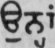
ਉਨ੍ਹਾਂ
